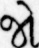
જો
